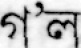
গ'ল
